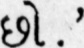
છો.'
